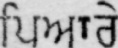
ਪਿਆਰੇ
